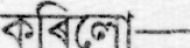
কৰিলো-
